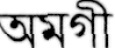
অমগী
